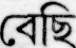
বেছি
